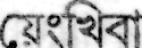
য়েংখিবা
